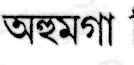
অহুমগা
